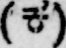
(ಕ)
